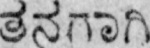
ತನಗಾಗಿ
